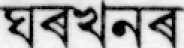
ঘৰখনৰ
